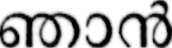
ഞാന്‍
